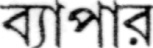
ব্যাপার
